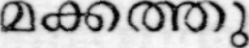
മക്കത്തു
